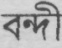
বন্দী
